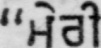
''ਮੇਰੀ
